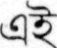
এই
